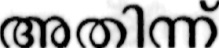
അതിന്ന്
